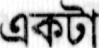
একটা
